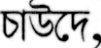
চাউদে,
